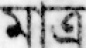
মাত্র
